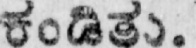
ಕಂಡಿತು.
